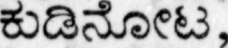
ಕುಡಿನೋಟ,
